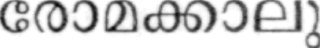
രോമക്കാലു
